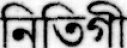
নিতিগী
